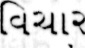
વિચાર
